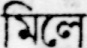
মিলে
